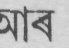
আৰ
